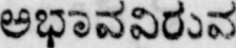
ಅಭಾವವಿರುವ
